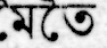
মৈতৈ
